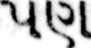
પણ
